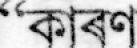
"কাৰণ
